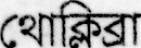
থোক্লিব্রা
